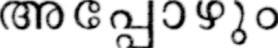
അപ്പോഴും
